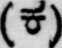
(ಕ)
